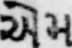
એમ
